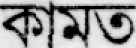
কামত
